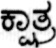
ಕ್ಷಾತ್ರ
